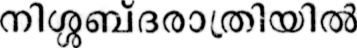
നിശ്ശബ്ദരാത്രിയില്‍
